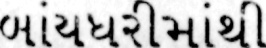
બાંયધરીમાંથી
